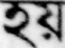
হয়
